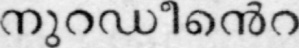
നുറഡീന്റെ
